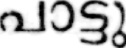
പാട്ടു
